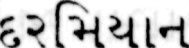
દરમિયાન
